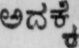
ಅದಕ್ಕೆ
